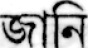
জানি
